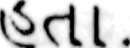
હતા.
